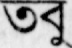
তবু
